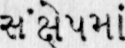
સંક્ષેપમાં
